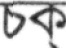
চক্
